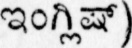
ಇಂಗ್ಲಿಷ್)
